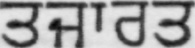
ਤਜਾਰਤ
